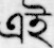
এই
